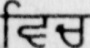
ਵਿਚ
